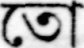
তো
